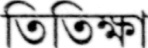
তিতিক্ষা
